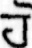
ਹੋ
